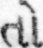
તો
